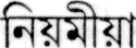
নিয়মীয়া
